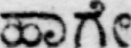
ಹಾಗೇ
